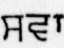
ਸਵਾ
